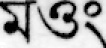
মওং
